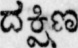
ದಕ್ಷಿಣ
